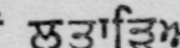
ਲਤਾੜਿਆ
